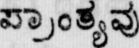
ಪ್ರಾಂತ್ಯವು
